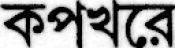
কপখরে
